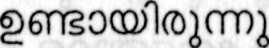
ഉണ്ടായിരുന്നു
